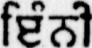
ਇੰਨੀ
